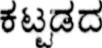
ಕಟ್ಟಡದ
